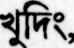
খুদিং,
